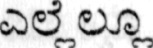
ಎಲ್ಲೆಲ್ಲೂ
